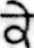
ਕੇ
